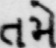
તમે
